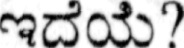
ಇದೆಯೆ?
